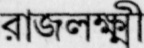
রাজলক্ষ্মী
